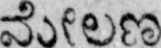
ಮೇಲಣ
